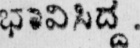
ಭಾವಿಸಿದ್ದ.
